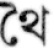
থৈ
